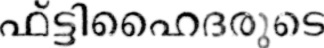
ഫ്ട്ടിഹൈദരുടെ
